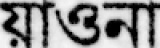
য়াওনা
